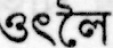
ওৎলৈ
